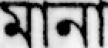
মানা
